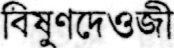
বিষুণদেওজী
